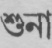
শুনা
